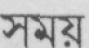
সময়
